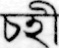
চহী
